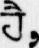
ਹੈ,
